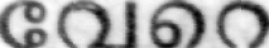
വേറെ
